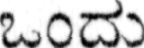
ಒಂದು
